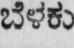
ಬೆಳಕು
